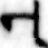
ન
